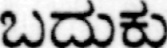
ಬದುಕು
